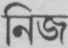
নিজ
